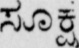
ಸೂಕ್ಷ್ಮ
